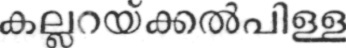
കല്ലറയ്ക്കല്‍പിള്ള
